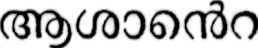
ആശാന്റെ
